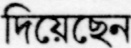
দিয়েছেন
